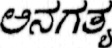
ಅನಗತ್ಯ
